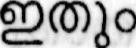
ഇതും
